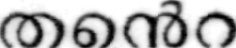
തന്റെ
